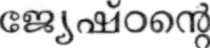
ജ്യേഷ്ഠന്റെ
